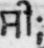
ਸੀ;
